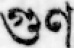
গুণ
